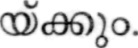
യ്ക്കും.
